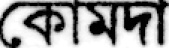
কোমদা
